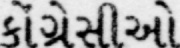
કોંગ્રેસીઓ
